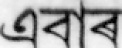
এবাৰ
